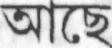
আছে
